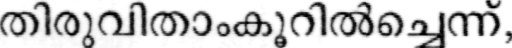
തിരുവിതാംകൂറില്‍ച്ചെന്ന്,
